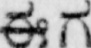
ಈಗ
